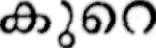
കുറെ
